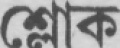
শ্লোক
